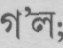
গ'ল;
